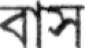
বাস
